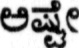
ಅಷ್ಟೇ
